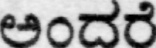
ಅಂದರೆ
